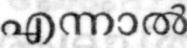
എന്നാല്‍
